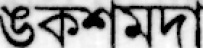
ঙকশমদা
